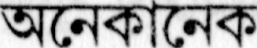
অনেকানেক
